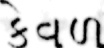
કેવળ
